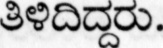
ತಿಳಿದಿದ್ದರು.
